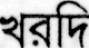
খরদি
